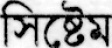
সিষ্টেম
